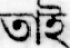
তাই
